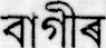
বাগীৰ
